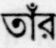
তাঁর
